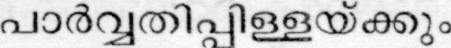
പാര്‍വ്വതിപ്പിള്ളയ്ക്കും
